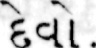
દેવો.
